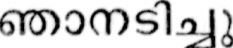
ഞാനടിച്ചു
